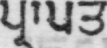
ਪ੍ਰਾਪਤ
